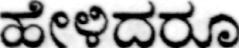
ಹೇಳಿದರೂ
